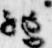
કહું
